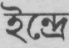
ইন্দ্ৰে
